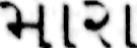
મારા
